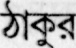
ঠাকুর
